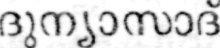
ദുന്യാസാദ്
